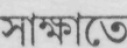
সাক্ষাতে
